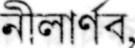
নীলার্ণব,
